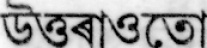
উত্তৰাওতো
